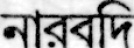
নারবদি
